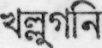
খল্লুগনি
